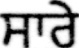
ਸਾਰੇ
